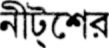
নীট্‌শের
